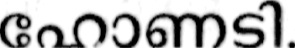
ഹോണടി.
